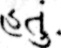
હતું.
